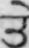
ਤੇ
